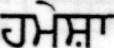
ਹਮੇਸ਼ਾ
